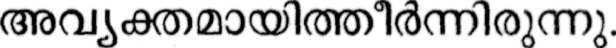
അവ്യക്തമായിത്തീര്‍ന്നിരുന്നു.
